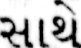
સાથે
